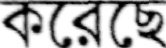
করেছে
